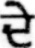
ਦੇ
